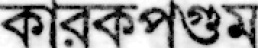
কারকপগুম
